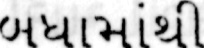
બધામાંથી
